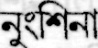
নুংশিনা
